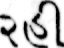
રહી
